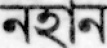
নহান
